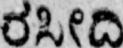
ರಸೀದಿ
